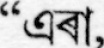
"এৰা,
